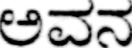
ಅವನ
